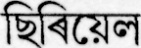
ছিৰিয়েল
